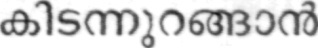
കിടന്നുറങ്ങാന്‍
